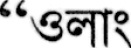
“ওলাং
